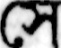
সে
